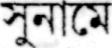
সুনামে
